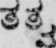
ತತ್ವ
